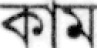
কাম
